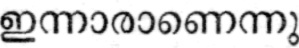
ഇന്നാരാണെന്നു
